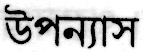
উপন্যাস
